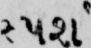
સ્પર્શ
